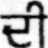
ਦੀ
